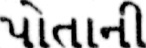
પોતાની
